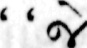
"જે
